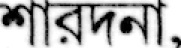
শারদনা,
